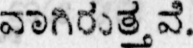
ವಾಗಿರುತ್ತವೆ.
